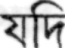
যদি
